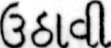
ઉઠાવી
